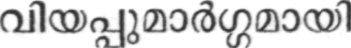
വിയപ്പുമാര്‍ഗ്ഗമായി
